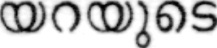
യറയുടെ
